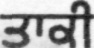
ਤਾਕੀ
